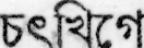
চৎখিগে
